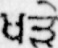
ਖੜੇ
